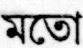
মতো
